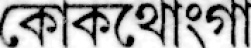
কোকথোংগা
